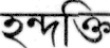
হন্দক্তি
